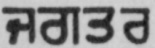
ਜਗਤਰ
